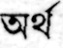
অর্থ
